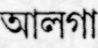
আলগা
